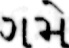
ગમે
